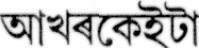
আখৰকেইটা
